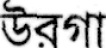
উরগা
